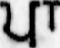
ਪਾ
